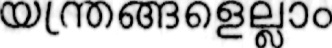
യന്ത്രങ്ങളെല്ലാം
